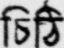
চিঠি
